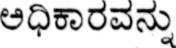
ಅಧಿಕಾರವನ್ನು
